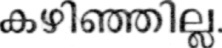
കഴിഞ്ഞില്ല.
